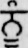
ਨੂੰ
